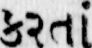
કરતાં
